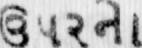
ઉપરનો
